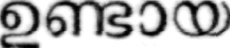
ഉണ്ടായ
